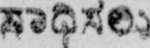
ಸಾಧಿಸಲು
